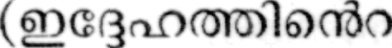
(ഇദ്ദേഹത്തിന്റെ
